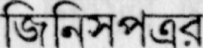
জিনিসপত্রর
